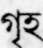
গৃহ
